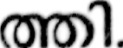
ത്തി.
